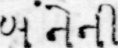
બંનેની
